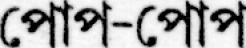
পোপ-পোক
